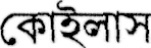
কোইলাস
